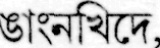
ঙাংনখিদে,
